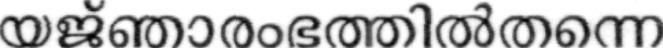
യജ്ഞാരംഭത്തില്‍തന്നെ
